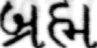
બ્રહ્મ
